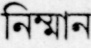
নিম্মান
